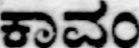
ಕಾವಂ
